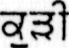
ਕੁੜੀ
